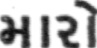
મારો
